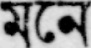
মনে
